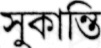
সুকান্তি
